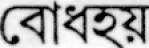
বোধহয়
